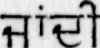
ਜਾਂਦੀ
